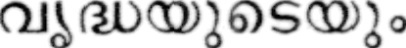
വൃദ്ധയുടെയും
